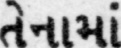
તેનામાં
